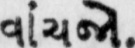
વાંચજો.
